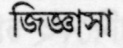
জিজ্ঞাসা
